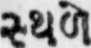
સ્થળે
